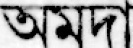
অমদা
